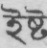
ইষ্ট
